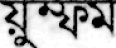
য়ুম্ফম
